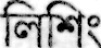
লিশিং
